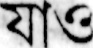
যাও
